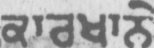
ਕਾਰਖਾਨੇ
